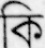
কি
